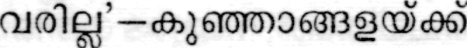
വരില്ല’-കുഞ്ഞാങ്ങളയ്ക്ക്
